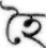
হৈ
